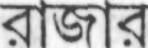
রাজার
